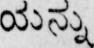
ಯನ್ನು
